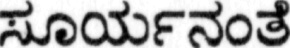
ಸೂರ್ಯನ೦ತೆ
